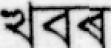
খবৰ
